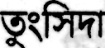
তুংসিদা
